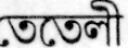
তেতেলী
